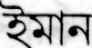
ইমান
